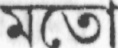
মতো
